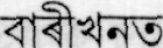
বাৰীখনত
